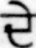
ਦੇ
